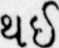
થઈ
